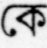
কে
